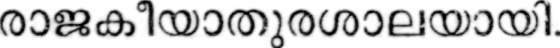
രാജകീയാതുരശാലയായി.
